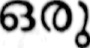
ഒരു
